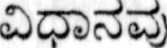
ವಿಧಾನವು
